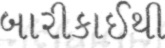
બારીકાઈથી
